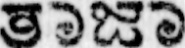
ತಾಜಾ
